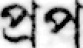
প্রপ
